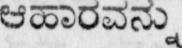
ಆಹಾರವನ್ನು
